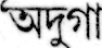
‘অদুগা
